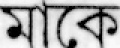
মাকে
